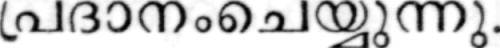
പ്രദാനംചെയ്യുന്നു.
